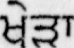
ਖੇੜਾ
